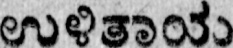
ಉಳಿತಾಯ
